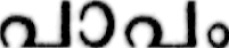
പാപം
